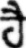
ਹੈ
